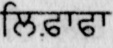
ਲਿਫ਼ਾਫਾ
